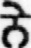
ਨੇ
